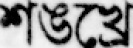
শঙখ্রে
